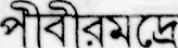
পীবীরমদ্রে
